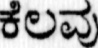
ಕೆಲವು
